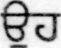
ਉਹ
